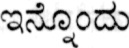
ಇನ್ನೊಂದು
